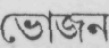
ভোজন
